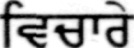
ਵਿਚਾਰੇ
